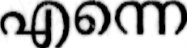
എന്നെ
